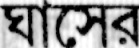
ঘাসের
